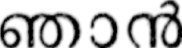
ഞാന്‍
